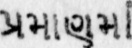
પ્રમાણમાં
